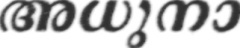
അധുനാ
